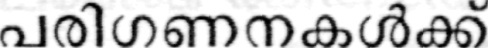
പരിഗണനകള്‍ക്ക്
